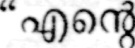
“എന്റെ
